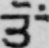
ਤੋਂ
